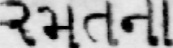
રમતના
